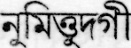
নুমিত্তুদগী
